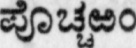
ಪೊಚ್ಚಱಂ
